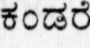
ಕಂಡರೆ
